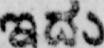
ಇದು
